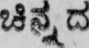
ಚಿನ್ನದ
